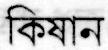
কিষান
